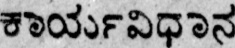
ಕಾರ್ಯವಿಧಾನ
